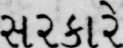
સરકારે
